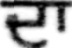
ਦਾ
